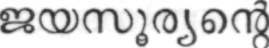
ജയസൂര്യന്റെ
